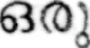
ഒരു
